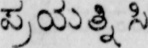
ಪ್ರಯತ್ನಿಸಿ
